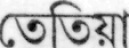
তেতিয়া
